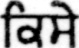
ਕਿਸੇ
